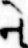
ને
